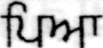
ਪਿਆ
